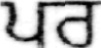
ਪਰ
